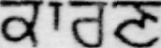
ਕਾਰਣ
